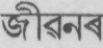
জীৱনৰ
